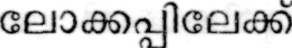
ലോക്കപ്പിലേക്ക്
